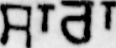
ਸਾਰਾ
